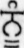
ਨੂੰ
